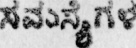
ಸಮಸ್ಯೆಗಳ
